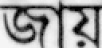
জায়
